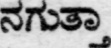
ನಗುತ್ತಾ
